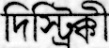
দিস্ট্রিক্কী
